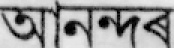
আনন্দৰ
